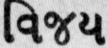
વિજય
